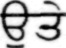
ਉਤੇ
